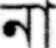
না
